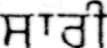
ਸਾਰੀ
